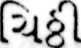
ચિઠ્ઠી
